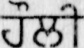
ਹੌਲੀ
